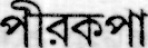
পীরকপা
